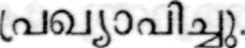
പ്രഖ്യാപിച്ചു.
